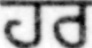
ਹਰ
